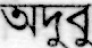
অদুবু
